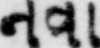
નવા
